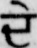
ਦੇ
